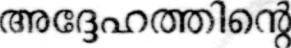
അദ്ദേഹത്തിന്റെ
